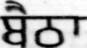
ਬੈਠਾ
